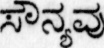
ಸೌನ್ಯವು
